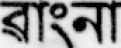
ৱাংনা
